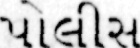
પોલીસ
